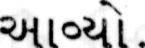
આવ્યો.
